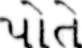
પોતે
